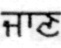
ਜਾਣ
